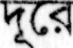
দূরে
